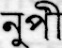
নুপী
